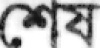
শেষ
